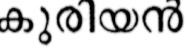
കുരിയന്‍
